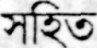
সহিত
